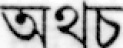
অথচ
